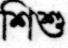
শিশু
